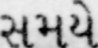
સમયે
